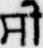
ਸੀ
